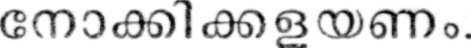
നോക്കിക്കളയണം.
